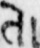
તો
